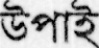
উপাই
